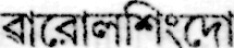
ৱারোলশিংদো
